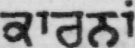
ਕਾਰਨਾਂ
